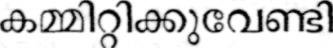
കമ്മിറ്റിക്കുവേണ്ടി
